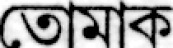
তোমাক
